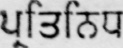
ਪ੍ਰਤਿਨਿਧ
